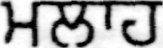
ਮਲਾਹ
